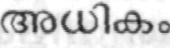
അധികം
